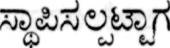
ಸ್ಥಾಪಿಸಲ್ಪಟ್ಟಾಗ
